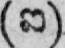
(ಐ)
